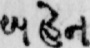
બહેન
